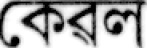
কেৱল
